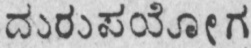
ದುರುಪಯೋಗ
